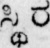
ಸ್ಥಿರ
